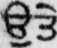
ਉਤੇ
